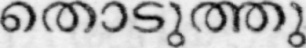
തൊടുത്തു
